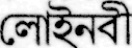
লোইনবী
